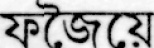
ফজৈয়ে
